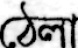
ঠেলা
